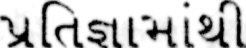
પ્રતિજ્ઞામાંથી
